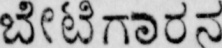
ಬೇಟೆಗಾರನ
